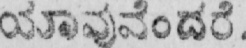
ಯಾವುವೆಂದರೆ.
